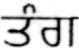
ਤੰਗ
